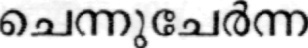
ചെന്നുചേര്‍ന്ന
